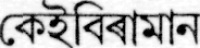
কেইবিৰামান
